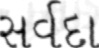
સર્વદા
